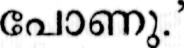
പോണു.’
